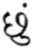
છું
